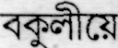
বকুলীয়ে
